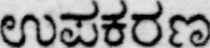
ಉಪಕರಣ
